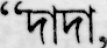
"দাদা,
